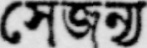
সেজন্য
